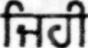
ਜਿਹੀ
